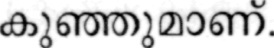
കുഞ്ഞുമാണ്.
